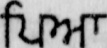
ਪਿਆ
